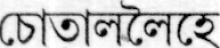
চোতাললৈহে
